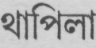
থাপিলা
